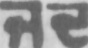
ਜਦ
